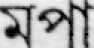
মপা
